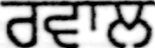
ਰਵਾਲ
